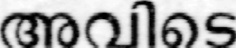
അവിടെ
